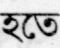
হতে
